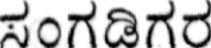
ಸಂಗಡಿಗರ
